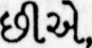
છીએ,
